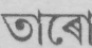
তাৰো
